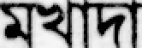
মখাদা
